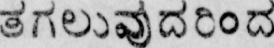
ತಗಲುವುದರಿಂದ
